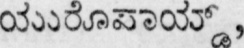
ಯುರೊಪಾಯ್ಡ್,
